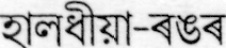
হালধীয়া-ৰঙৰ
